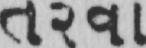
તરવા
